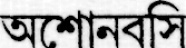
অশোনবসি
